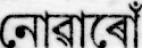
নোৱাৰোঁ
